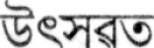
উৎসৱত
